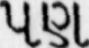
પણ
